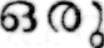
ഒരു
